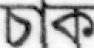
চাক
